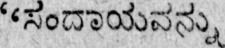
“ಸಂದಾಯವನ್ನು
